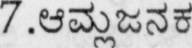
7.ಆಮ್ಲಜನಕ
